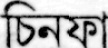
চিনফা
